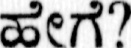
ಹೇಗೆ?
